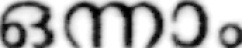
ഒന്നാം
